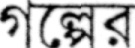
গল্পের
